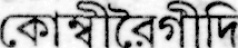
কোম্বীরৈগীদি
